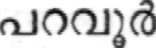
പറവൂര്‍
